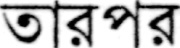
তারপর
